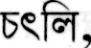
চৎলি,
